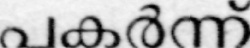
പകര്‍ന്ന്
